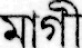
মাগী
